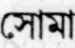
সোমা
